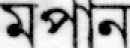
মপান
